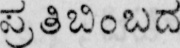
ಪ್ರತಿಬಿಂಬದ
